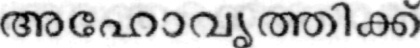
അഹോവൃത്തിക്ക്
